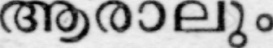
ആരാലും
